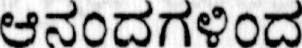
ಆನಂದಗಳಿಂದ
